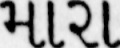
મારા
